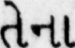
તેના
